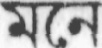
মনে
